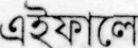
এইফালে
